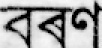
বৰণ
